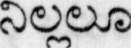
ನಿಲ್ಲಲೂ
